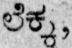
ಲೆಕ್ಕ,
